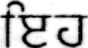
ਇਹ
